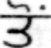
ਤੋਂ
